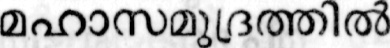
മഹാസമുദ്രത്തില്‍
